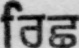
ਰਿਛ
